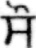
ਸੌ
